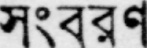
সংবরণ
